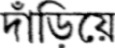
দাঁড়িয়ে
